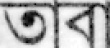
তাবা
